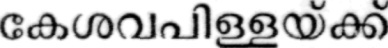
കേശവപിള്ളയ്ക്ക്
